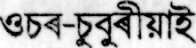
ওচৰ-চুবুৰীয়াই
